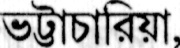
ভট্টাচারিয়া,
